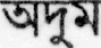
অদুম
